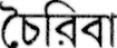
চৈরিবা
